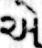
એ
